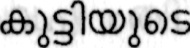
കുട്ടിയുടെ
